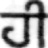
ਹੀ
